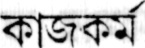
কাজকর্ম
